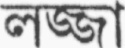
লজ্জা
